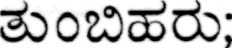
ತುಂಬಿಹರು;
